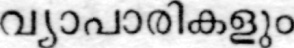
വ്യാപാരികളും
